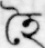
হৈ
